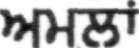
ਅਮਲਾਂ
